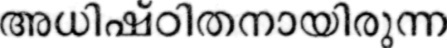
അധിഷ്ഠിതനായിരുന്ന
